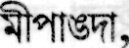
মীপাঙদা,
